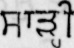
ਸਾੜ੍ਹੀ
